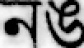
নঙ
